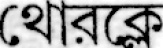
থোরক্লে
